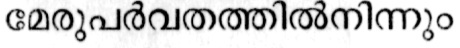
മേരുപര്‍വതത്തില്‍നിന്നും
